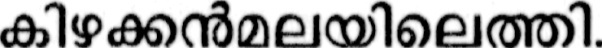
കിഴക്കന്‍മലയിലെത്തി.
